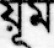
য়ূম
